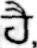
ਹੈ,
